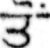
ਤੋਂ
